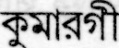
কুমারগী
